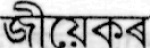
জীয়েকৰ
